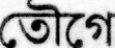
তৌগে
